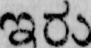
ಇರು
